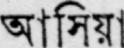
আসিয়া
